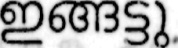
ഇങ്ങട്ടു.
